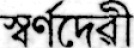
স্বর্ণদেৱী
